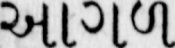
આગળ
